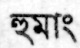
হুমাং
